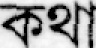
কথা
